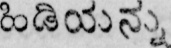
ಹಿಡಿಯನ್ನು
